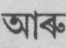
আৰু
